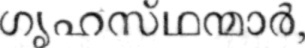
ഗൃഹസ്ഥന്മാര്‍,
